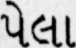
પેલા
